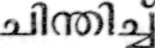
ചിന്തിച്ച്
